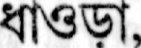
ধাওড়া,
